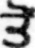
ਤੋਂ
